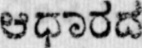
ಆಧಾರದ
